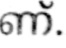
ണ്.
